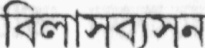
বিলাসব্যসন
